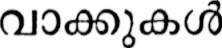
വാക്കുകള്‍
